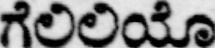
ಗೆಲಿಲಿಯೊ
